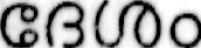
ദേശം
